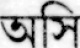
অসি
